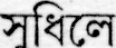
সুধিলে
